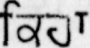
ਕਿਹਾ
